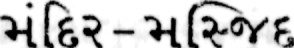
મંદિર-મસ્જિદ
